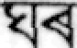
ঘৰ
